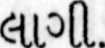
લાગી.
